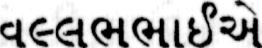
વલ્લભભાઈએ
